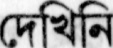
দেখিনি
